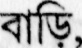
বাড়ি,
